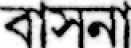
বাসনা
